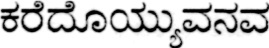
ಕರೆದೊಯ್ಯುವನವ
